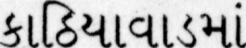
કાઠિયાવાડમાં
